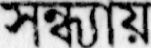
সন্ধ্যায়
